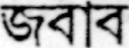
জবাব
